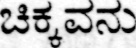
ಚಿಕ್ಕವನು
